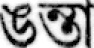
ঙন্তা
